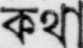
কথা
